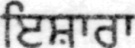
ਇਸ਼ਾਰਾ
